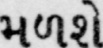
મળશે
